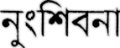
নুংশিবনা
